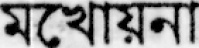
মখোয়না
